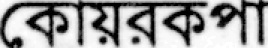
কোয়রকপা
